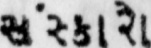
સંસ્કારો
